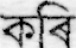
কৰি
